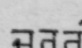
ਜ਼ਰੂਰੀ
